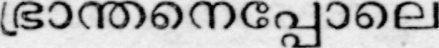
ഭ്രാന്തനെപ്പോലെ
